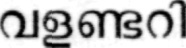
വളണ്ടറി
